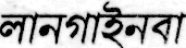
লানগাইনবা
